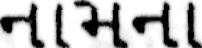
નામના
